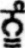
ਨੂੰ
